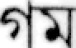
গম
